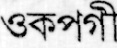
ওকপগী
